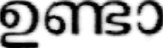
ഉണ്ടാ
